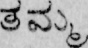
ತಮ್ಮ
